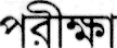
পরীক্ষা
